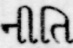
નીતિ
